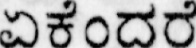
ಏಕೆಂದರೆ
